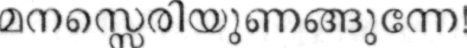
മനസ്സെരിയുണങ്ങുന്നേ!
